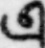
এ
